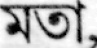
মতা,
